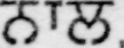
ਨਾਲ,
